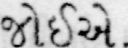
જોઈએ.
